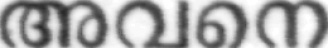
അവനെ
